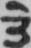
ਤੇ
